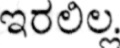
ಇರಲಿಲ್ಲ.
